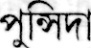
পুন্সিদা
